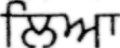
ਲਿਆ
